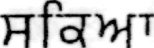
ਸਕਿਆ
